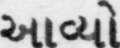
આવ્યો
